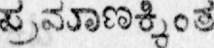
ಪ್ರಮಾಣಕ್ಕಿಂತ
